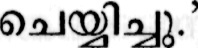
ചെയ്യിച്ചു.’
